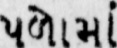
પળોમાં
